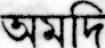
অমদি
